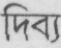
দিব্য
